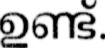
ഉണ്ട്.
